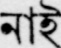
নাই
